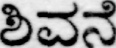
ಶಿವನೆ
